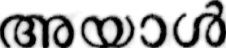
അയാള്‍
